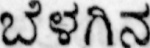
ಬೆಳಗಿನ
